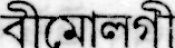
বীমোলগী
